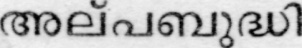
അല്പബുദ്ധി
